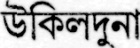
উকিলদুনা
